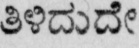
ತಿಳಿದುದೇ
